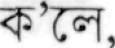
ক'লে,
